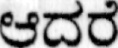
ಆದರೆ
